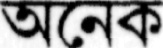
অনেক
